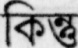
কিন্তু
